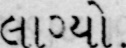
લાગ્યો.
